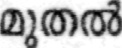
മുതല്‍
